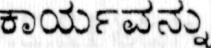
ಕಾರ್ಯವನ್ನು
